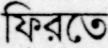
ফিরতে
